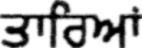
ਤਾਰਿਆਂ
